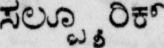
ಸಲ್ಪ್ಯೂರಿಕ್
